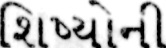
શિષ્યોની
